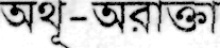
অথূ-অরাক্তা
